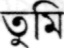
তুমি
